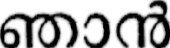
ഞാന്‍
